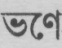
ভণে
